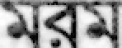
মরম
